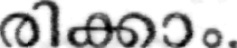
രിക്കാം.
